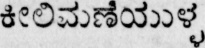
ಕೀಲಿಮಣೆಯುಳ್ಳ
